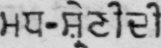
ਮਧ-ਸ਼੍ਰੇਣੀਦੀ
